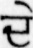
ਦੇ
